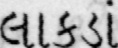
લાકડાં
